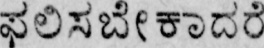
ಫಲಿಸಬೇಕಾದರೆ
